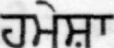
ਹਮੇਸ਼ਾ
